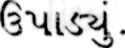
ઉપાડ્યું.
